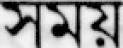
সময়
